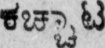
ಕಚ್ಚಾಟ
